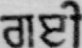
ਗਈ
